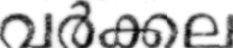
വര്‍ക്കല
